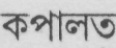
কপালত
